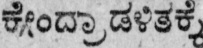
ಕೇಂದ್ರಾಡಳಿತಕ್ಕೆ
